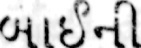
બાઈની
